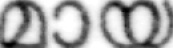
മായ
